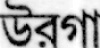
উরগা
